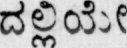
ದಲ್ಲಿಯೇ
